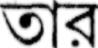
তার
